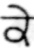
ਕੇ
